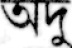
অদু
